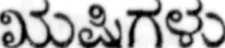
ಋಷಿಗಳು
